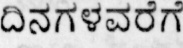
ದಿನಗಳವರೆಗೆ
